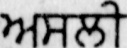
ਅਸਲੀ
